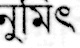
নুমিৎ
